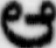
ಆ
